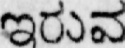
ಇರುವ
